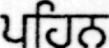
ਪਹਿਨ
